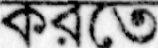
করতে
